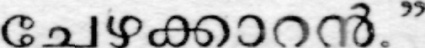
ചേഴക്കാറന്‍."
